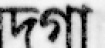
দগা
